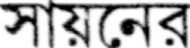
সায়নের
